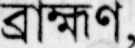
ব্রাহ্মণ,
